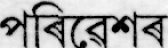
পৰিৱেশৰ
